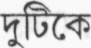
দুটিকে
